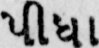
પીધા
